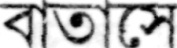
বাতাসে
